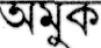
অমুক
